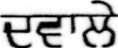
ਦਵਾਲੇ
